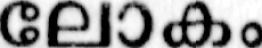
ലോകം
